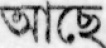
আছে
